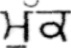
ਮੁੱਕ
